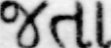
જતા
